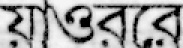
য়াওররে
